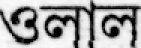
ওলাল
